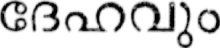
ദേഹവും
